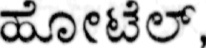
ಹೋಟೆಲ್,
